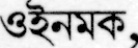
ওইনমক,
